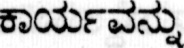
ಕಾರ್ಯವನ್ನು
